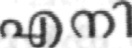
എനി
